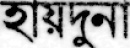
হায়দুনা
